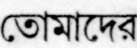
তোমাদের
